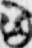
છે
